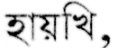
হায়খি,
